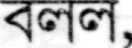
বলল,
